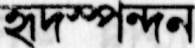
হৃদস্পন্দন
